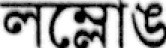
লম্লোঙ
